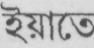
ইয়াতে
